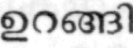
ഉറങ്ങി
